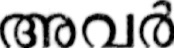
അവര്‍
